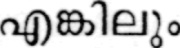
എങ്കിലും
